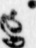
હું
